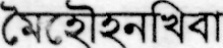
মৈহৌহনখিবা
